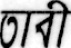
তাবী
